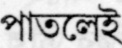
পাতলেই
